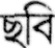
ছবি
